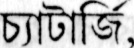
চ্যাটার্জি,
